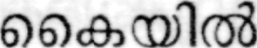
കൈയില്‍
